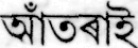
আঁতৰাই
